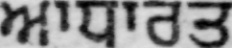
ਆਧਾਰਤ
